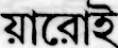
য়ারোই
